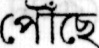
পৌঁছে
